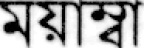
ময়াম্বা
